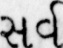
સર્વ
